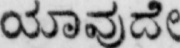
ಯಾವುದೇ
